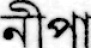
নীপা
